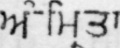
ਅੰਮ੍ਰਿਤਾ
